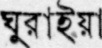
ঘুরাইয়া
